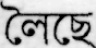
লৈছে
